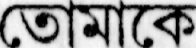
তোমাকে
